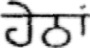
ਹੇਠਾਂ
